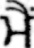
ਮੈਂ
